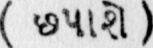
(છપાશે)
